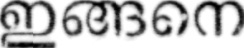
ഇങ്ങനെ
